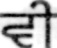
ਵੀ
